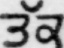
ਤੱਕ
